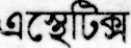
এস্থেটিক্স
